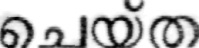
ചെയ്ത
